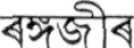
ৰঙ্গজীৰ
